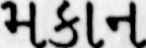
મકાન
